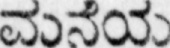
ಮನೆಯ
